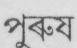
পুৰুষ
